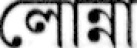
লোন্না
